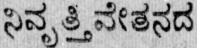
ನಿವೃತ್ತಿವೇತನದ
